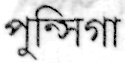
পুন্সিগা
